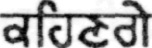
ਕਹਿਣਗੇ
